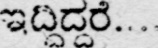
ಇದ್ದಿದ್ದರೆ..
